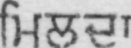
ਮਿਲਦਾ
